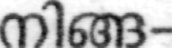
നിങ്ങ-
